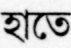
হাতে
